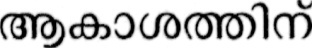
ആകാശത്തിന്
